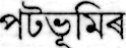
পটভূমিৰ
